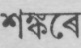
শঙ্কৰে
